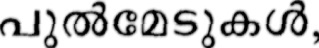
പുല്‍മേടുകള്‍,
